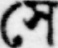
সে
